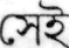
সেই
